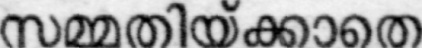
സമ്മതിയ്ക്കാതെ
